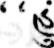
"હું
